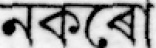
নকৰো
